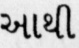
આથી
